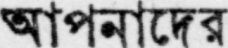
আপনাদের
